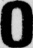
O
